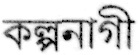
কল্পনাগী
